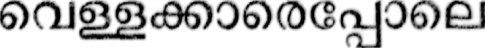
വെള്ളക്കാരെപ്പോലെ
